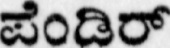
ಪೆಂಡಿರ್
